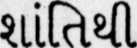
શાંતિથી
